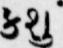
કશું
